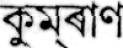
কুম্‌ৰাণ
